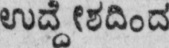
ಉದ್ದೇಶದಿಂದ
